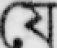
যে
